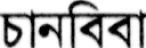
চানবিবা
